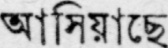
আসিয়াছে
